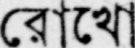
রোখো
